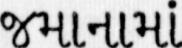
જમાનામાં
